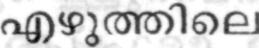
എഴുത്തിലെ
